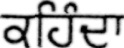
ਕਹਿੰਦਾ
